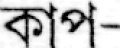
কাপ-
